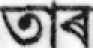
তাৰ
